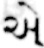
એ
